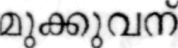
മുക്കുവന്
